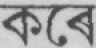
কৰে
